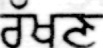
ਰੱਖਣ
